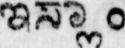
ಇಸ್ಲಾಂ
